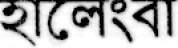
হালেংবা
